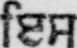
ਇਸ
